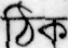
ঠিক
